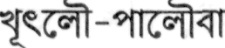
খূৎলৌ-পালৌবা
